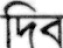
দিব
